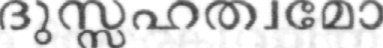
ദുസ്സഹത്വമോ
